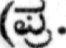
(ಪ್ರ.
